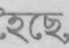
হৈছে,
